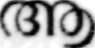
ആ
